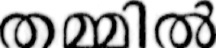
തമ്മില്‍
